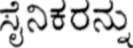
ಸೈನಿಕರನ್ನು
